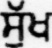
ਸੁੱਖ
